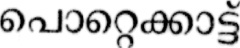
പൊറ്റെക്കാട്ട്
